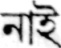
নাই
